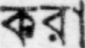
করা
